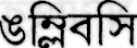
ঙম্লিবসি
